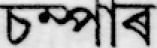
চম্পাৰ
